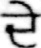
ਦੇ
